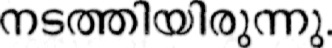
നടത്തിയിരുന്നു.
